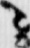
કે
